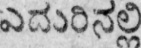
ಎದುರಿನಲ್ಲಿ
